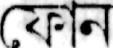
ফোন
